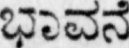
ಭಾವನೆ
